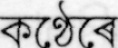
কণ্ঠেৰে
